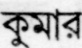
কুমার
